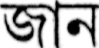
জান
